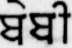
ਬੇਬੀ
